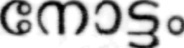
നോട്ടം
